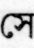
সে
